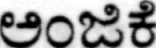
ಅಂಜಿಕೆ
